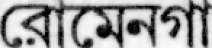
রোমেনগা
